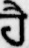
ਹੈ
